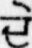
ਦੇ
